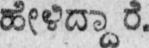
ಹೇಳಿದ್ದಾರೆ.
